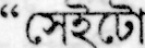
"সেইটো
